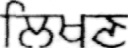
ਲਿਖਣ
